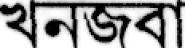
খনজবা
